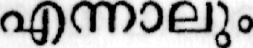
എന്നാലും
